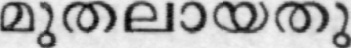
മുതലായതു
